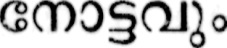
നോട്ടവും
